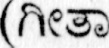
(ಗೀತಾ
